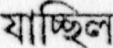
যাচ্ছিল
